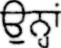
ਉਨ੍ਹਾਂ
